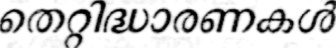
തെറ്റിദ്ധാരണകള്‍
